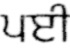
ਪਈ
